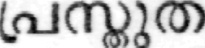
പ്രസ്തുത
